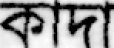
কাদা
